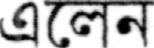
এলেন
